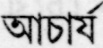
আচার্য
